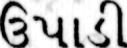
ઉપાડી
